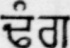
ਢੰਗ
